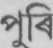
পুৰি
